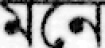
মনে
